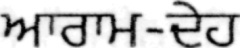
ਆਰਾਮ-ਦੇਹ
